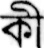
কী
